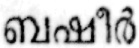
ബഷീര്‍
